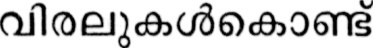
വിരലുകള്‍കൊണ്ട്
